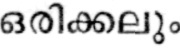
ഒരിക്കലും
